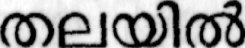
തലയില്‍
